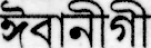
ঈবানীগী
